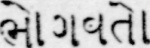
ભોગવતો
